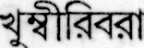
খুম্বীরিবরা
